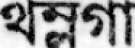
থম্লগা
